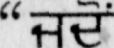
''ਜਦੋਂ
